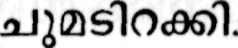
ചുമടിറക്കി.
